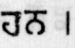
ਹਨ।
